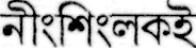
নীংশিংলকই
